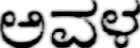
ಅವಳ
